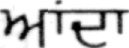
ਆਂਦਾ
